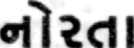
નોરતા
